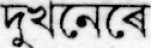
দুখনেৰে
